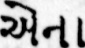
એના
